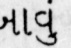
આવું
